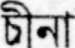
চীনা
